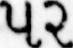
પર
